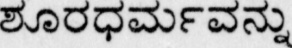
ಶೂರಧರ್ಮವನ್ನು
